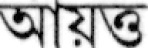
আয়ত্ত
